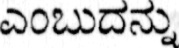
ಎಂಬುದನ್ನು
